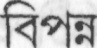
বিপন্ন
